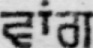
ਵਾਂਗ
